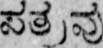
ಪತ್ರವು
